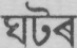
ঘটৰ
